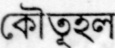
কৌতূহল
